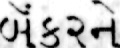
બૅંકરને
